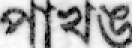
পাখঙ
